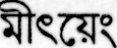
মীৎয়েং
